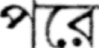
পরে
